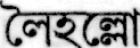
লৈহল্লো
